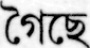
গৈছে
